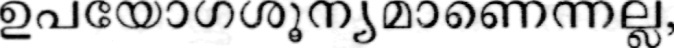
ഉപയോഗശൂന്യമാണെന്നല്ല,
